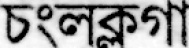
চংলক্লগা
